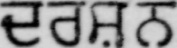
ਦਰਸ਼ਨ
